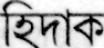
হিদাক
